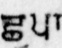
ਛੁਪਾ
